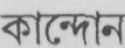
কান্দোন
